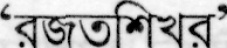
‘রজতশিখর’
